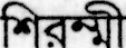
শিরম্মী
